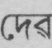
দেৱ
